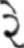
રે
